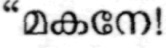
“മകനേ!
